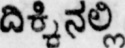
ದಿಕ್ಕಿನಲ್ಲಿ
